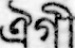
ঐগী
